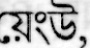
য়েংউ,
